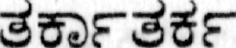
ತರ್ಕಾತರ್ಕ
